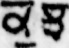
ਕੁਝ
